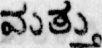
ಮತ್ತು
